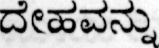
ದೇಹವನ್ನು
